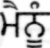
ਮੈਨੂੰ
